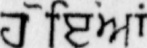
ਹੋਇਆਂ
